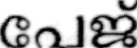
പേജ്
